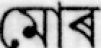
মোৰ
